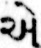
એ
